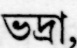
ভদ্রা,
